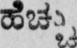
ಹೆಚ್ಚು
